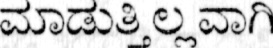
ಮಾಡುತ್ತಿಲ್ಲವಾಗಿ
